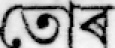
তোৰ
